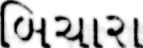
બિચારા
